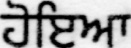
ਹੋਇਆ
